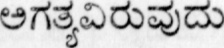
ಅಗತ್ಯವಿರುವುದು
